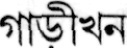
গাড়ীখন
